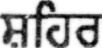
ਸ਼ਹਿਰ
